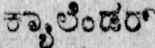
ಕ್ಯಾಲೆಂಡರ್
